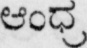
ಆಂಧ್ರ
